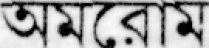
অমরোম
